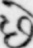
છે
